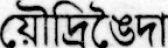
য়ৌদ্রিঙৈদা
